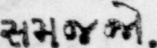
સમજજો.
